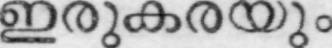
ഇരുകരയും
